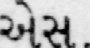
એસ.
